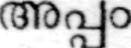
അപ്പം
